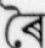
ৰৈ
